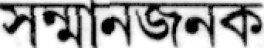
সন্মানজনক
